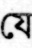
যে
